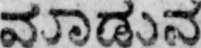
ಮಾಡುವ
